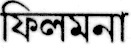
ফিলমনা
